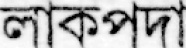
লাকপদা
